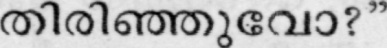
തിരിഞ്ഞുവോ?"
